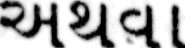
અથવા
